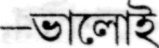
-ভালোই
